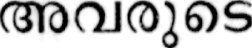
അവരുടെ
